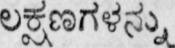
ಲಕ್ಷಣಗಳನ್ನು
